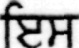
ਇਸ
